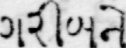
ગરીબને
